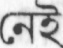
নেই
